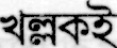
খল্লকই
